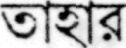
তাহার
